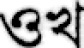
ওখ
